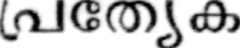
പ്രത്യേക
